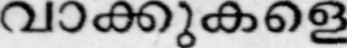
വാക്കുകളെ
